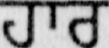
ਹਾਰ
